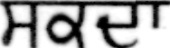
ਸਕਦਾ
